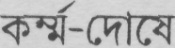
কৰ্ম্ম-দোষে
